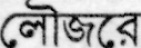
লৌজরে
